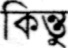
কিন্তু
